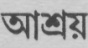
আশ্ৰয়
